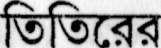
তিতিরের
